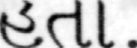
હતા.
